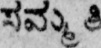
ಸಮ್ಮತಿ
